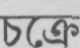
চক্ৰে
